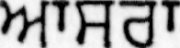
ਆਸਰਾ
